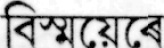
বিস্ময়েৰে
